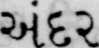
અંદર
